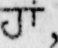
ਹਾਂ,
